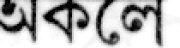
অকলে
